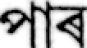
পাৰ
